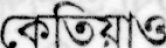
কেতিয়াও
